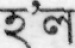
হ'ল
